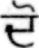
ਦੋ
